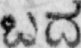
ಬದ
